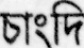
চাংদিল
